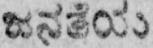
ಜನತೆಯ
